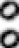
ঃ
